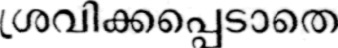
ശ്രവിക്കപ്പെടാതെ
